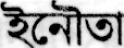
ইনৌতা
